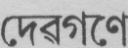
দেৱগণে
